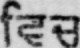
ਵਿਚ
